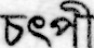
চৎপী
